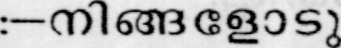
:-നിങ്ങളോടു
